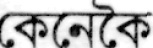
কেনেকৈ
